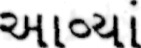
આવ્યાં
